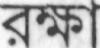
রক্ষা
